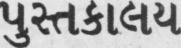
પુસ્તકાલય
